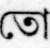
তো
